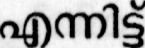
എന്നിട്ട്
